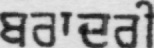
ਬਰਾਦਰੀ
